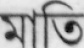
মাতি
